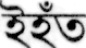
ইহঁত
